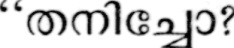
"തനിച്ചോ?
